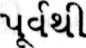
પૂર્વથી
